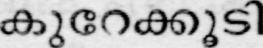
കുറേക്കൂടി
